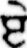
ਏ
